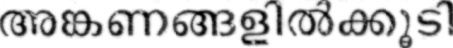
അങ്കണങ്ങളില്‍ക്കൂടി
